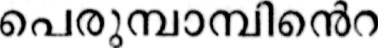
പെരുമ്പാമ്പിന്റെ
